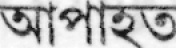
আপাহত
